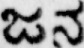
ಜನ
